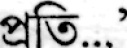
প্রতি...'
